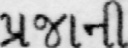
પ્રજાની
